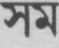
সম
